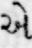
એ
